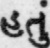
હતું
